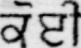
ਕੋਈ
